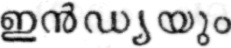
ഇന്‍ഡ്യയും
